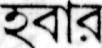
হবার
